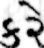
કરે
